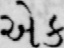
એક
